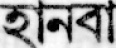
হানবা
